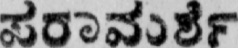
ಪರಾಮರ್ಶೆ
